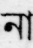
না
